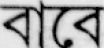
বাবে
